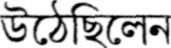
উঠেছিলেন
